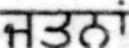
ਜਤਨਾਂ
